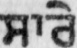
ਸਾਰੇ
